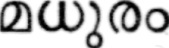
മധുരം
